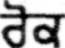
ਰੋਕ
